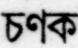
চণক
